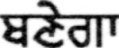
ਬਣੇਗਾ
